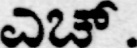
ಎಚ್.
